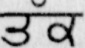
ਤੱਕ
